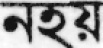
নহয়
